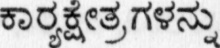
ಕಾರ್‍ಯಕ್ಷೇತ್ರಗಳನ್ನು
